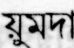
য়ুমদা
